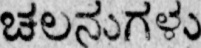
ಚಲನುಗಳು
